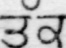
ਤੱਕ
